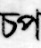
চপ
